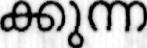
ക്കുന്ന
